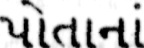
પોતાનાં
